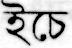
ইচে
